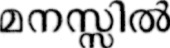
മനസ്സില്‍
